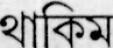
থাকিম
